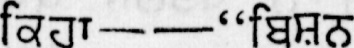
ਕਿਹਾ-''ਬਿਸ਼ਨ
